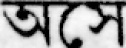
অসে
